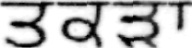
ਤਕੜਾ
